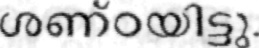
ശണ്ഠയിട്ടു.
